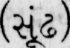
(સૂંઢ)
